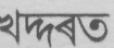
খদ্দৰত
